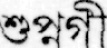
শুপ্নগী
